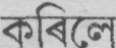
কৰিলে
